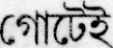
গোটেই
